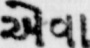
એવા
